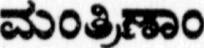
ಮಂತ್ರಿಣಾಂ
